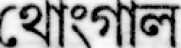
থোংগাল
